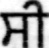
ਸੀ
